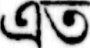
এত
